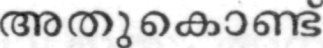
അതുകൊണ്ട്
